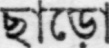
ছাড়ো
